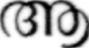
ആ
